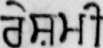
ਰੇਸ਼ਮੀ
